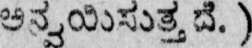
ಅನ್ವಯಿಸುತ್ತದೆ.)
